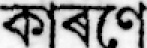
কাৰণে
